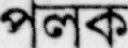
পলক
